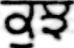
ਕੁਝ
